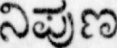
ನಿಪುಣ
